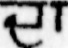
ਦਾ
